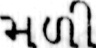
મળી
